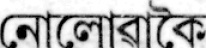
নোলোৱাকৈ
